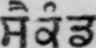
ਸੈਕੰਡ
